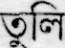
তুলি
